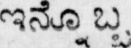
ಇನ್ನೊಬ್ಬ
